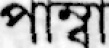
পাম্বা
